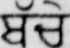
ਬੱਚੇ
